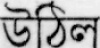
উঠিল
